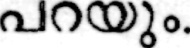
പറയും.
